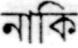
নাকি
